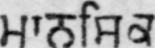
ਮਾਨਸਿਕ
